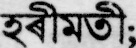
হৰীমতী;
